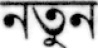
নতুন
